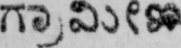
ಗ್ರಾಮೀಣ
